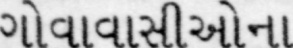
ગોવાવાસીઓના
